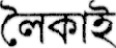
লৈকাই
